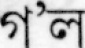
গ'ল
